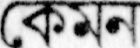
কেমন
